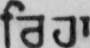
ਰਿਹਾ
